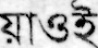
য়াওই
